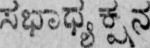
ಸಭಾಧ್ಯಕ್ಷನ
